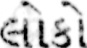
લોકો
